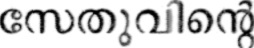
സേതുവിന്റെ
